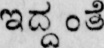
ಇದ್ದಂತೆ
